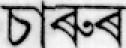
চাৰুৰ
